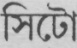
সিটো
